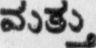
ಮತ್ತು
